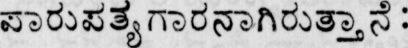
ಪಾರುಪತ್ಯಗಾರನಾಗಿರುತ್ತಾನೆ:
